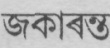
জকাৰন্ত
